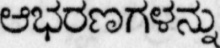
ಆಭರಣಗಳನ್ನು
